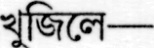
খুজিলে-
